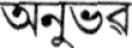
অনুভৱ
